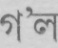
গ'ল
